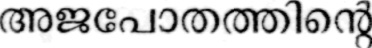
അജപോതത്തിന്റെ
